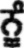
ਨੂੰ
